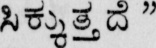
ಸಿಕ್ಕುತ್ತದೆ”
